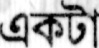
একটা
